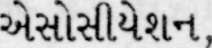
એસોસીયેશન,
